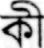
কী
